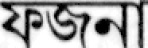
ফজনা
